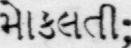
મોકલતી;
